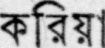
করিয়া
